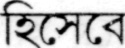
হিসেবে
